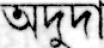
অদুদা
